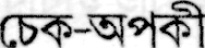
চেক-অপকী
